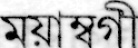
ময়াম্বগী
